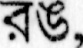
রঙ,
